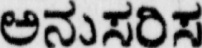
ಅನುಸರಿಸ
